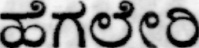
ಹೆಗಲೇರಿ
